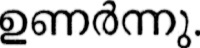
ഉണര്‍ന്നു.
